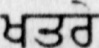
ਖਤਰੇ
